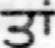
ਤਾਂ
